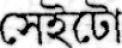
সেইটো
